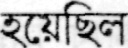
হয়েছিল
